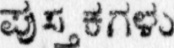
ಪುಸ್ತಕಗಳು
